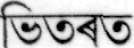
ভিতৰত
